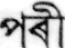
পৰী
